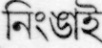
নিংঙাই
